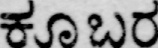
ಕೂಬರ
